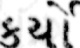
કર્યો
